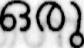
ഒരു
